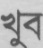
খুব
